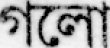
গলো
